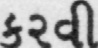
કરવી
